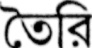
তৈরি
